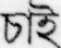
চাই
